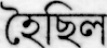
হৈছিল
